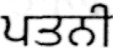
ਪਤਨੀ
